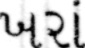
ખરાં
